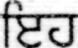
ਇਹ
